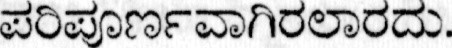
ಪರಿಪೂರ್ಣವಾಗಿರಲಾರದು.
